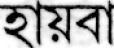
হায়বা
